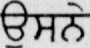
ਉਸਨੇ
